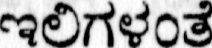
ಇಲಿಗಳಂತೆ
